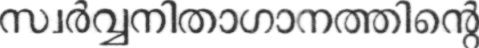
സ്വര്‍വ്വനിതാഗാനത്തിന്റെ
